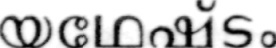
യഥേഷ്ടം
